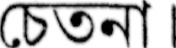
চেতনা।
